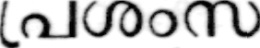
പ്രശംസ
